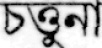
চত্তুনা
